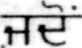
ਜਦੋਂ
